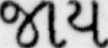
જાય
